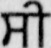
ਸੀ
